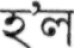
হ'ল
